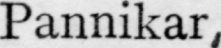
Pannikar,
